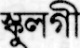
স্কুলগী
